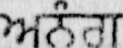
ਅਨੰਗ
